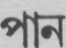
পান
